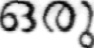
ഒരു
